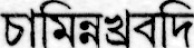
চামিন্নখ্রবদি
